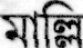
মাল্লি
